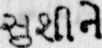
સુશીને
